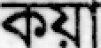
কয়া
